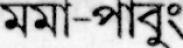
মমা-পাবুং
